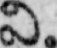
ವಿ.
